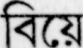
বিয়ে
